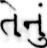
તેનું
